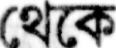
থেকে
